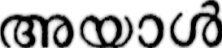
അയാള്‍
